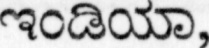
ಇಂಡಿಯಾ,
